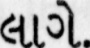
લાગે.
